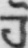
ਹੋ
